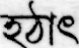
হঠাৎ
